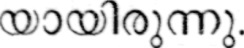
യായിരുന്നു.
